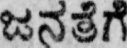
ಜನತೆಗೆ
